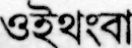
ওইথংবা
